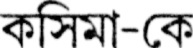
কসিমা-কে
